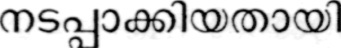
നടപ്പാക്കിയതായി
